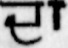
ਦਾ
